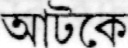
আটকে
